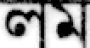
লম
